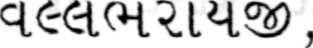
વલ્લભરાયજી,
